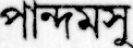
পান্দমসু
